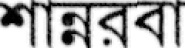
শান্নরবা
